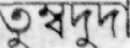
তুম্বদুদা
